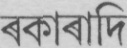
ৰকাৰাদি
